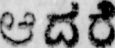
ಆದರೆ
